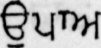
ਉਪਾਅ
